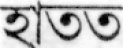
হাতত
